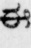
ಈ
